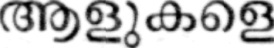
ആളുകളെ
